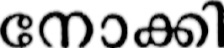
നോക്കി
